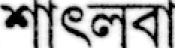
শাৎলবা
